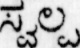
ಸ್ವಲ್ಪ
